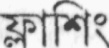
ফ্লাশিং
